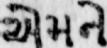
એમને
